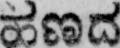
ಹಣದ
